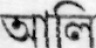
আলি
